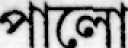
পালো
